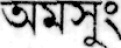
অমসুং
